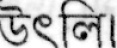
উৎলি।
